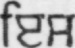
ਇਸ
